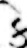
કે
